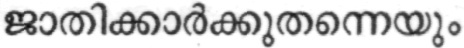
ജാതിക്കാര്‍ക്കുതന്നെയും
